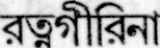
রত্নগীরিনা
